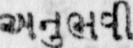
અનુભવી
